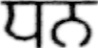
ਧਨ
